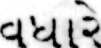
વધારે
